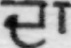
ਦਾ
